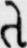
તે
